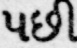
પછી
